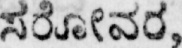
ಸರೋವರ,
